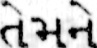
તેમને
